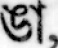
ঙা,
